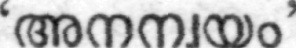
'അനന്വയം'
